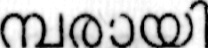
മ്പരായി
